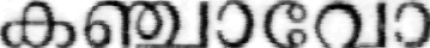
കഞ്ചാവോ
